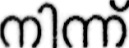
നിന്ന്
